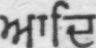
ਆਦਿ
